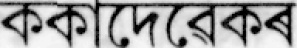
ককাদেৱেকৰ
